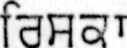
ਰਿਸਕਾ
